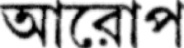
আরোপ
